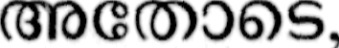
അതോടെ,
